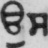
ਉਸ
